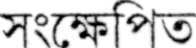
সংক্ষেপিত
